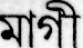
মাগী
